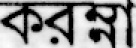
করম্না
